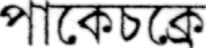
পাকেচক্রে
